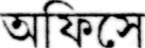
অফিসে
